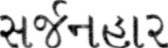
સર્જનહાર
